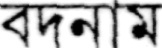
বদনাম
